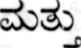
ಮತ್ತು
